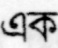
এক
